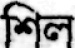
শিল
